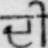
ਦੀ
